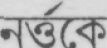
নৰ্ত্তকে
